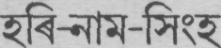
হৰি-নাম-সিংহ
